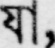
যা,
